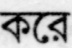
করে
